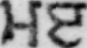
ਮੲ
